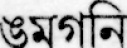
ঙমগনি
